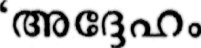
‘അദ്ദേഹം
